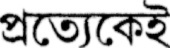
প্রত্যেকেই
